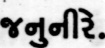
જનુનીરે.
